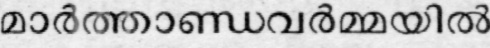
മാര്‍ത്താണ്ഡവര്‍മ്മയില്‍
